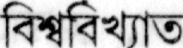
বিশ্ববিখ্যাত
